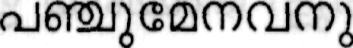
പഞ്ചുമേനവനു
